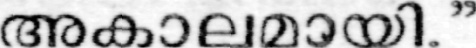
അകാലമായി."
